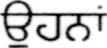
ਉਹਨਾ
